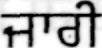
ਜਾਰੀ
